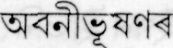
অবনীভূষণৰ
